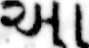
આ
